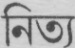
নিত্য
